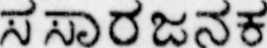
ಸಸಾರಜನಕ
